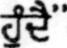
ਹੁੰਦੈ''
